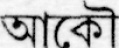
আকৌ
